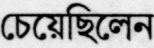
চেয়েছিলেন
